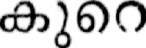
കുറെ
